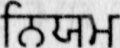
ਨਿਯਮ
